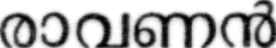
രാവണന്‍
